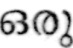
ഒരു
